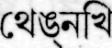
থেঙনখি
